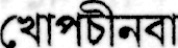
খোপচীনবা
